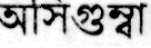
অসিগুম্বা
